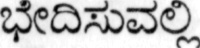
ಭೇದಿಸುವಲ್ಲಿ
